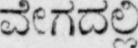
ವೇಗದಲ್ಲಿ
